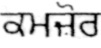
ਕਮਜ਼ੋਰ
